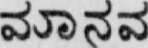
ಮಾನವ
